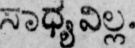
ಸಾಧ್ಯವಿಲ್ಲ.
